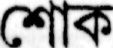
শোক
